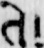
તો
